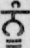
ਨੂੰ
